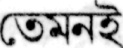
তেমনই
